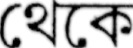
থেকে
